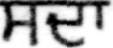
ਸਦਾ
